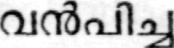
വന്‍പിച്ച
